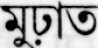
মুঢ়াত
